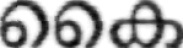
കൈ
